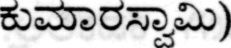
ಕುಮಾರಸ್ವಾಮಿ)
